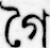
গৈ
